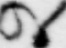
જ
